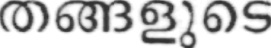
തങ്ങളുടെ
